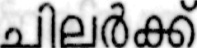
ചിലര്‍ക്ക്
